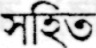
সহিত
